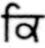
ਕਿ
